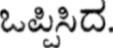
ಒಪ್ಪಿಸಿದ.
